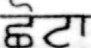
ਛੋਟਾ
